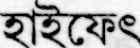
হাইফেৎ
